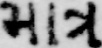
માત્ર
